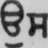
ਉਸ
